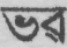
ভৱ
